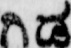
ಗಿಡ
